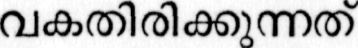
വകതിരിക്കുന്നത്
